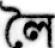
লৈ
